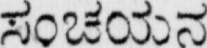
ಸಂಚಯನ
